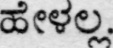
ಹೇಳಲ್ಲ.
